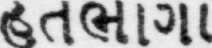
હતભાગા
